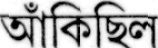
আঁকিছিল
